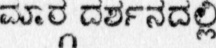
ಮಾರ್‍ಗದರ್ಶನದಲ್ಲಿ
